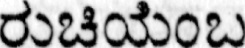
ರುಚಿಯೆಂಬ
